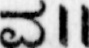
ವ||
